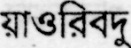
য়াওরিবদু
